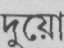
দুয়ো
